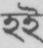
হই
